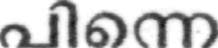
പിന്നെ
